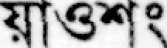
য়াওশং
